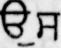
ਉਸ
